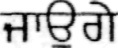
ਜਾਉਗੇ
